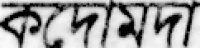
কদোমদা
